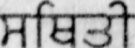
ਸਥਿਤੀ
